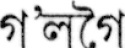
গ'লগৈ
